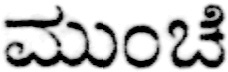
ಮುಂಚೆ
